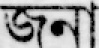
জনা
